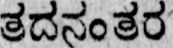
ತದನಂತರ
